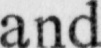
and
